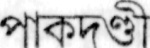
পাকদণ্ডী
